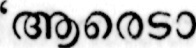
‘ആരെടാ
